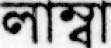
লম্বা
